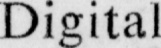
Digital
